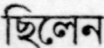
ছিলেন
